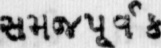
સમજપૂર્વક
